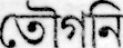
তৌগনি
